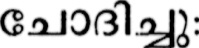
ചോദിച്ചു:
